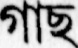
গাছ
